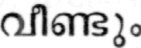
വീണ്ടും
